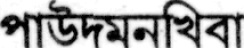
পাউদমনখিবা
